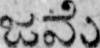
ಜಮೆ
